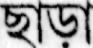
ছাড়া
